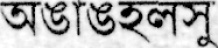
অঙাঙহলসু
